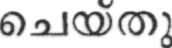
ചെയ്തു
